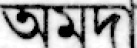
অমদা
